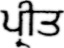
ਪ੍ਰੀਤ
